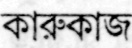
কারুকাজ
